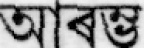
আৰম্ভ
